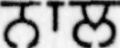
ਨਾਲ
